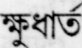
ক্ষুধার্ত
